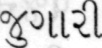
જુગારી
